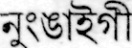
নুংঙাইগী
